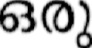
ഒരു
